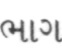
ભાગ
